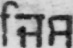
ਜਿਸ
